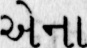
એના
